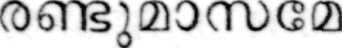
രണ്ടുമാസമേ
